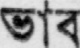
ভাব
